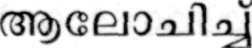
ആലോചിച്ച്
